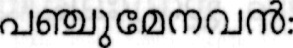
പഞ്ചുമേനവന്‍:
